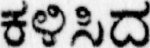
ಕಳಿಸಿದ
